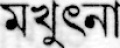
হায়না
